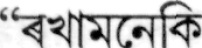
"ৰখামনেকি
